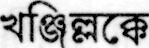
খঞ্জিল্লক্কে
